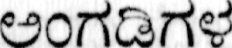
ಅಂಗಡಿಗಳ
